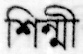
শিন্মী
